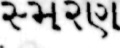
સ્મરણ
